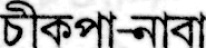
চীকপা-নাবা
